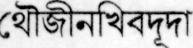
থৌজীনখিবদূদা
